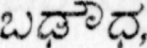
ಬಢೌಧ,
